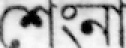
শেংনা
